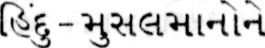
હિંદુ-મુસલમાનોને
